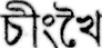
চীংখৈ
